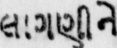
લાગણીને
